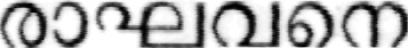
രാഘവനെ
